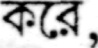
করে,
